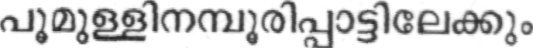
പൂമുള്ളിനമ്പൂരിപ്പാട്ടിലേക്കും
